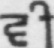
ਵੀ
